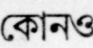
কোনও
